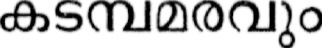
കടമ്പമരവും
